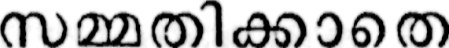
സമ്മതിക്കാതെ
